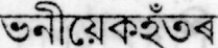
ভনীয়েকহঁতৰ
